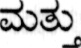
ಮತ್ತು
